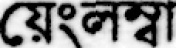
য়েংলম্বা
